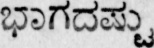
ಭಾಗದಷ್ಟು
